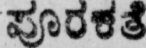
ಪೂರಕತೆ
